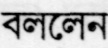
বললেন
